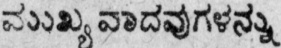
ಮುಖ್ಯವಾದವುಗಳನ್ನು
